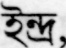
ইন্দ্র,
